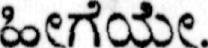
ಹೀಗೆಯೇ.
